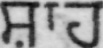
ਸ਼ਾਹ
